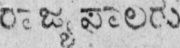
ರಾಜ್ಯಪಾಲರು
